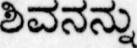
ಶಿವನನ್ನು
